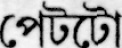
পেটটো
